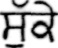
ਸੁੱਕੇ
